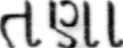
તણા
